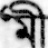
‘মী
